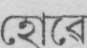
হোৱে
